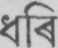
ধৰি
